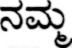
ನಮ್ಮ
